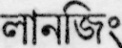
লানজিং
